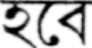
হবে
